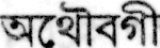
অথৌবগী
